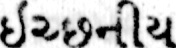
ઇચ્છનીય
